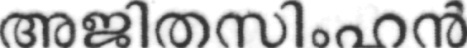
അജിതസിംഹന്‍
